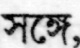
সঙ্গে,
